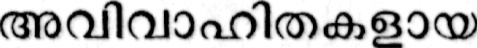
അവിവാഹിതകളായ
